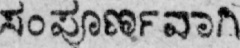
ಸಂಪೂರ್ಣವಾಗಿ
